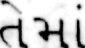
તેમાં
